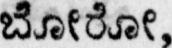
ಬೋರೋ,
